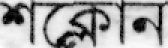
শক্লোন
